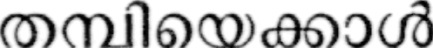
തമ്പിയെക്കാള്‍
